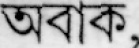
অবাক,
